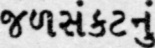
જળસંકટનું
